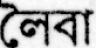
লৈবা
